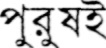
পুরুষই
